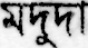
মদুদা
